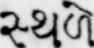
સ્થળે
